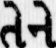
તેને
